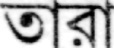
তারা
